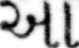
આ
